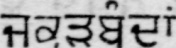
ਜਕੜਬੰਦਾਂ
